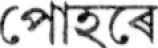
পোহৰে
